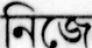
নিজে
